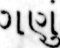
ગણું
